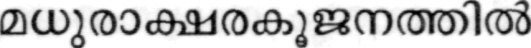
മധുരാക്ഷരകൂജനത്തില്‍
